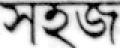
সহজ
